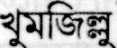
খুমজিল্লু
